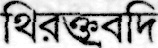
থিরক্ত্রবদি
